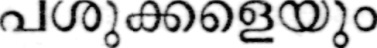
പശുക്കളെയും
